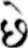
છે
